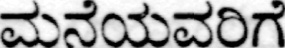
ಮನೆಯವರಿಗೆ
